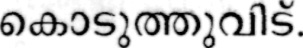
കൊടുത്തുവിട്.
